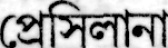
প্রেসিলানা
